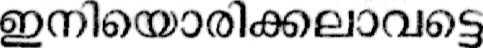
ഇനിയൊരിക്കലാവട്ടെ
